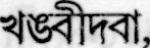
খঙবীদবা,
